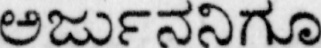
ಅರ್ಜುನನಿಗೂ
